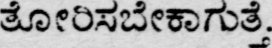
ತೋರಿಸಬೇಕಾಗುತ್ತೆ.
